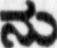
ನು
